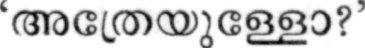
'അത്രേയുള്ളോ?'
